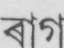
ৰাগ
